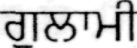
ਗੁਲਾਮੀ
